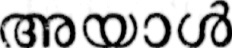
അയാള്‍
